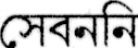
সেবননি
